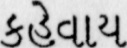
કહેવાય
